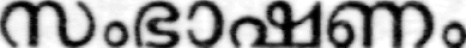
സംഭാഷണം
